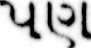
પણ
